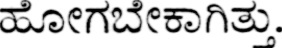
ಹೋಗಬೇಕಾಗಿತ್ತು.
